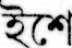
ইশে
